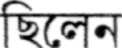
ছিলেন
